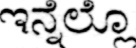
ಇನ್ನೆಲ್ಲೊ
